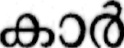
കാര്‍
